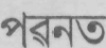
পৱনত
